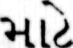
માટે
